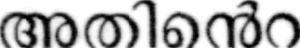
അതിന്റെ
